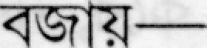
বজায়-
